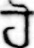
ਹੋ
